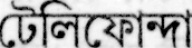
টেলিফোন্দা
